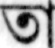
তা
